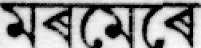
মৰমেৰে
